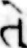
તે
